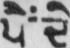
ਪੈਂਦੇ
